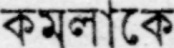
কমলাকে
